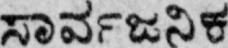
ಸಾರ್ವಜನಿಕ
